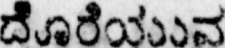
ದೊರೆಯುವ
